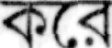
করে
